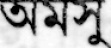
অমসু
